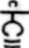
ਨੂੰ
